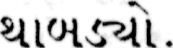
થાબડ્યો.
